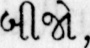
બીજો,
